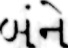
બંને
